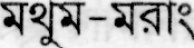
মথুম-মরাং
